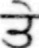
ਤੇ
